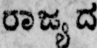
ರಾಜ್ಯದ
